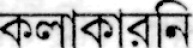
কলাকারনি
